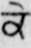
ਕੇ
